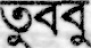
তুববু
